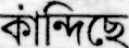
কান্দিছে
